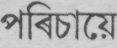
পৰিচায়ে
